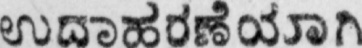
ಉದಾಹರಣೆಯಾಗಿ
